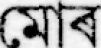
মোৰ
